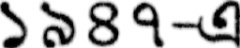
১৯৪৭-এ
